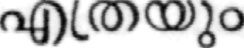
എത്രയും
